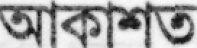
আকাশত
